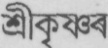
শ্ৰীকৃষ্ণৰ
